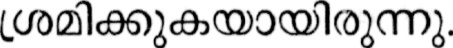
ശ്രമിക്കുകയായിരുന്നു.
